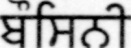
ਬੌਸਿਨੀ
